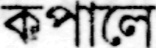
কপালে
